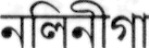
নলিনীগা
